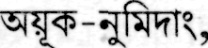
অয়ূক-নুমিদাং,
